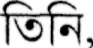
তিনি,
